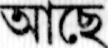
আছে
